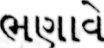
ભણાવે
